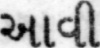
આવી
